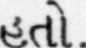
હતો.
